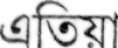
এতিয়া
